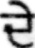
ਦੇ
